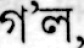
গ'ল,
